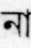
না
